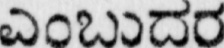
ಎಂಬುದರ
